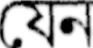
যেন
